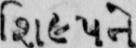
શિલ્પને
